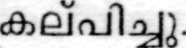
കല്പിച്ചു.
